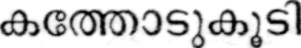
കത്തോടുകൂടി
